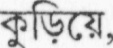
কুড়িয়ে,
